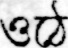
ওঠে
